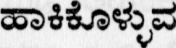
ಹಾಕಿಕೊಳ್ಳುವ
